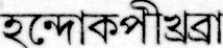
হন্দোকপীখ্রব্রা
